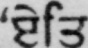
'ਏਤਿ
